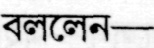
বললেন–
